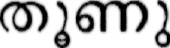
തൂണു
